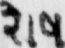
રોષ
